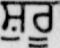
ਸ਼ੁਰੂ
